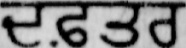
ਦਫ਼ਤਰ
